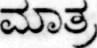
ಮಾತ್ರ
